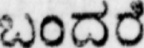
ಬಂದರೆ
